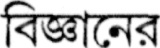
বিজ্ঞানের
